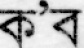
ক'ব
